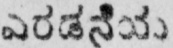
ಎರಡನೆಯ
